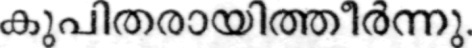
കുപിതരായിത്തീര്‍ന്നു.
